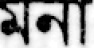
মনা
